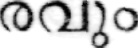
രവും
